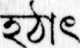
হঠাৎ
